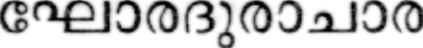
ഘോരദുരാചാര
